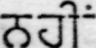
ਨਹੀਂ
